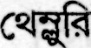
থেম্লুরি
